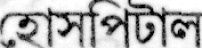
হোসপিটাল
